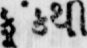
ફૂંકથી
